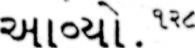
આવ્યો.૧૨૮
